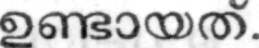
ഉണ്ടായത്.
